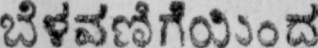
ಬೆಳವಣಿಗೆಯಿ೦ದ
